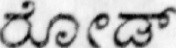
ರೋಡ್
